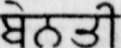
ਬੇਨਤੀ
